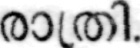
രാത്രി.
